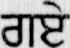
ਗਏ
